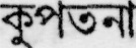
কুপতনা
